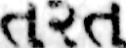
તરત
